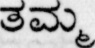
ತಮ್ಮ
